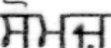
ਸੋਮਜ਼
